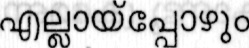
എല്ലായ്പ്പോഴും
